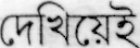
দেখিয়েই
